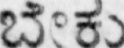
ಬೇಕು
